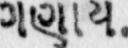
ગણાય.
